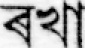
ৰখা
